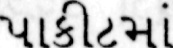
પાકીટમાં
